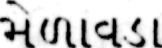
મેળાવડા
